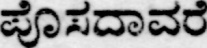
ಪೊಸದಾವರೆ
